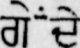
ਗੇਂਦੇ
